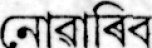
নোৱাৰিব
